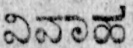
ವಿವಾಹ
